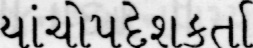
યાંચોપદેશકર્તા
